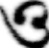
ও
